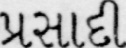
પ્રસાદી
